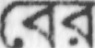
বের
